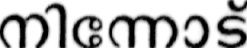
നിന്നോട്
